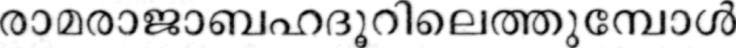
രാമരാജാബഹദൂറിലെത്തുമ്പോള്‍
